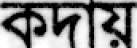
কদায়
